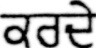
ਕਰਦੇ
